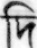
দি
